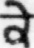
ਕੇ
